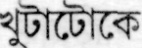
খুটাটোকে
